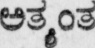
ಅತ್ಯಂತ
